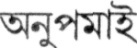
অনুপমাই
